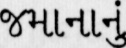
જમાનાનું
